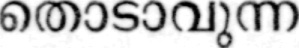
തൊടാവുന്ന
